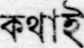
কথাই
